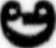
ಅ
